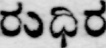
ರುಧಿರ
